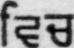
ਵਿਚ
